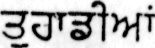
ਤੁਹਾਡੀਆਂ
